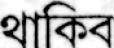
থাকিব
